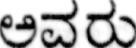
ಅವರು
